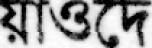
য়াওদে
